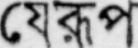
যেরূপ
